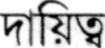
দায়িত্ব
